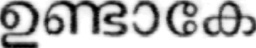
ഉണ്ടാകേ
